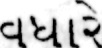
વધારે
